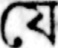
যে
